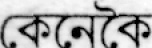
কেনেকৈ
